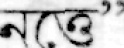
নত্তে”
